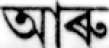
আৰু
